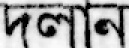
দলান
